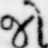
જો
